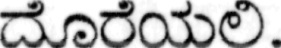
ದೊರೆಯಲಿ.
